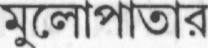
মুলোপাতার
